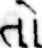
તો
